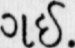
ગઈ.
